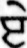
ਏ
